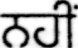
ਨਹੀਂ
